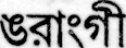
ঙরাংগী
